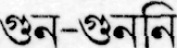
গুন-গুননি
